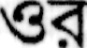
ওর
